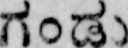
ಗಂಡು
